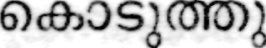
കൊടുത്തു
